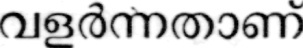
വളര്‍ന്നതാണ്
